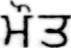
ਮੌਤ
